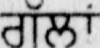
ਗੱਲਾਂ
